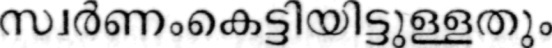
സ്വര്‍ണംകെട്ടിയിട്ടുള്ളതും
